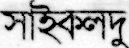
সাইকলদু
